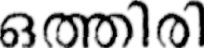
ഒത്തിരി
